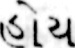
હોય
